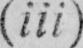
(iii)
